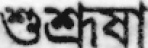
শুশ্রষা
